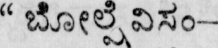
“ಬೋಲ್ಷೆವಿಸಂ-
